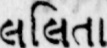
લલિતા
